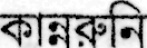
কান্নরুনি
